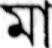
মা
